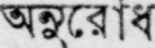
অনুরোধ
